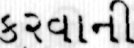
કરવાની
